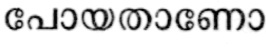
പോയതാണോ
